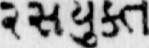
રસયુક્ત
